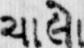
ચાલો
